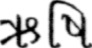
ઋષિ
